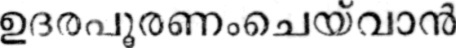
ഉദപൂരണംചെയ്വാന്‍
